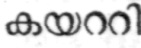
കയററി
